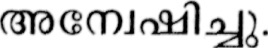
അന്വേഷിച്ചു.
